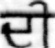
ਦੀ
